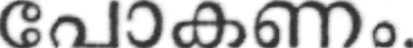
പോകണം.
